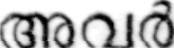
അവര്‍
